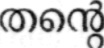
തന്റെ
